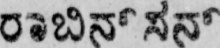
ರಾಬಿನ್‌ಸನ್
